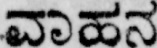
ವಾಹನ
